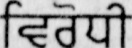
ਵਿਰੋਧੀ
